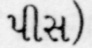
પીસ)
